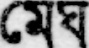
মেঘ
